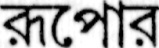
রূপোর
